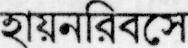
হায়নরিবসে
